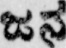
ಜನ
